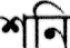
শনি
